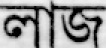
লাজ
